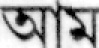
আম
